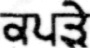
ਕਪੜੇ
